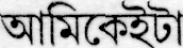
আমিকেইটা
